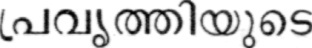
പ്രവൃത്തിയുടെ
